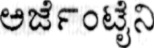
ಅರ್ಜೆಂಟೈನಿ
